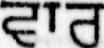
ਵਾਰ
